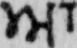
ਆ
